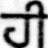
ਹੀ
